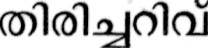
തിരിച്ചറിവ്
